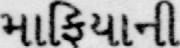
માફિયાની
